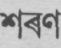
শৰণ
